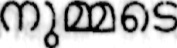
നുമ്മടെ
